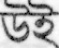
উই
